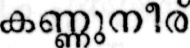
കണ്ണുനീര്
